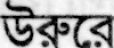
উরুরে
